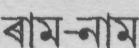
ৰাম-নাম
